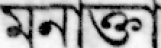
মনাক্তা
